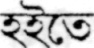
হইতে
